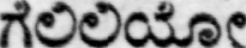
ಗೆಲಿಲಿಯೋ
